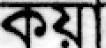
কয়া
